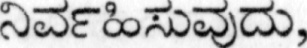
ನಿರ್ವಹಿಸುವುದು,
